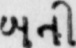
બની
